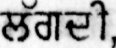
ਲੱਗਦੀ,
